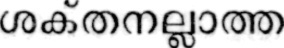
ശക്തനല്ലാത്ത
